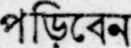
পড়িবেন
